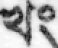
খং
